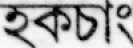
হকচাং
